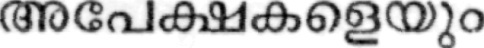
അപേക്ഷകളെയും
